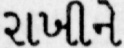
રાખીને
